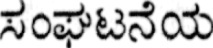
ಸಂಘಟನೆಯ
